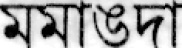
মমাঙদা
